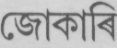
জোকাৰি
